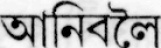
আনিবলৈ
